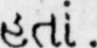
હતાં.
